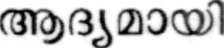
ആദ്യമായി
